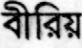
বীরিয়
